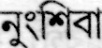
নুংশিবা
